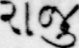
રાજુ
